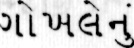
ગોખલેનું
